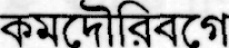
কমদৌরিবগে
